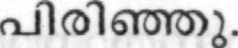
പിരിഞ്ഞു.
